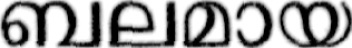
ബലമായ
